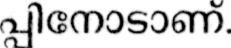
പ്പിനോടാണ്.
